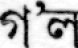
গ'ল
